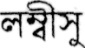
লম্বীসু
